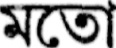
মতো
